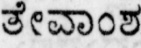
ತೇವಾಂಶ
